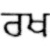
ਰਖ
